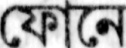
ফোনে
